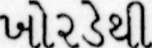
ખોરડેથી
